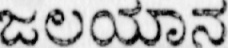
ಜಲಯಾನ
